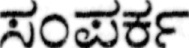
ಸಂಪರ್ಕ
